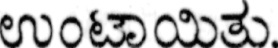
ಉಂಟಾಯಿತು.
